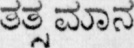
ತತ್ಸಮಾನ
